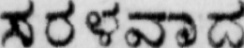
ಸರಳವಾದ
